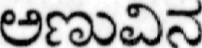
ಅಣುವಿನ
